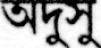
অদুসু
